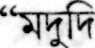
“মদুদি
